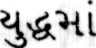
યુદ્ધમાં
